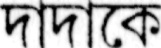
দাদাকে
